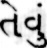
તેવું
